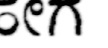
ಹೇಗೆ
